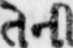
તેની
